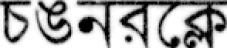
চঙনরক্লে
